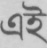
এই
